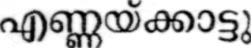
എണ്ണയ്ക്കാട്ടു
